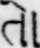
તો
